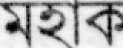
মহাক
